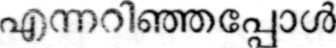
എന്നറിഞ്ഞപ്പോള്‍
